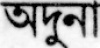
অদুনা
